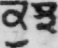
ਕੁਝ
